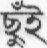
ছুঁই
